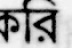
করি
